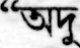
“অদু
